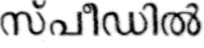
സ്പീഡില്‍
